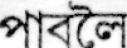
পাবলৈ
